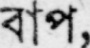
বাপ,
